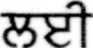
ਲਈ
